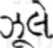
ઝૂલે
